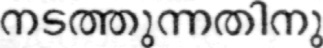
നടത്തുന്നതിനു
